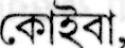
কোইবা,
